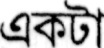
একটা
